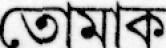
তোমাক
